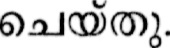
ചെയ്തു.
